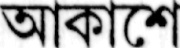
আকাশে
